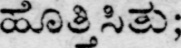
ಹೊತ್ತಿಸಿತು;
